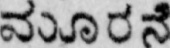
ಮೂರನೆ
